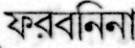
ফরবনিনা
